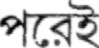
পরেই
